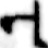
ન
